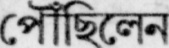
পৌঁছিলেন
